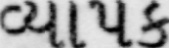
વ્યાપક
